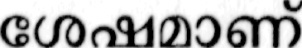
ശേഷമാണ്
